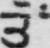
ਤੋਂ
